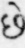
છે
